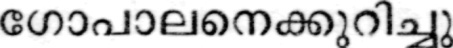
ഗോപാലനെക്കുറിച്ചു
